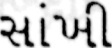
સાંખી
